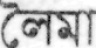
লৈমা
